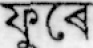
ফুৰে
